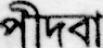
পীদবা
